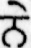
ਨੇ
